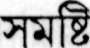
সমষ্টি
